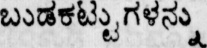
ಬುಡಕಟ್ಟುಗಳನ್ನು
